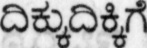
ದಿಕ್ಕುದಿಕ್ಕಿಗೆ
